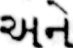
અને
